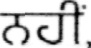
ਨਹੀਂ,
